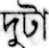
দুটা
